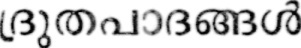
ദ്രുതപാദങ്ങള്‍
